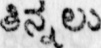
ತಿನ್ನಲು
